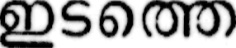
ഇടത്തെ
